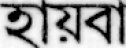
হায়বা
